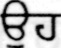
ਉਹ
